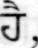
ਹੈ,
